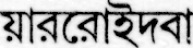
য়াররোইদবা
